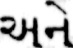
અને
